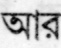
আর
